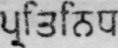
ਪ੍ਰਤਿਨਿਧ
